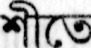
শীতে
